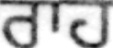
ਰਾਹ
